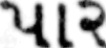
પાર
